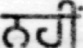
ਨਹੀਂ
